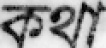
কথা
